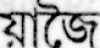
য়াজৈ
